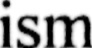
ism
